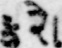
કરો
